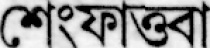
শেংফাত্তবা
